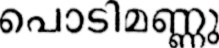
പൊടിമണ്ണു
